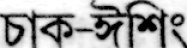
চাক-ঈশিং
